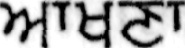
ਆਖਣਾ
